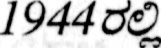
1944ರಲ್ಲಿ
